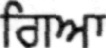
ਗਿਆ
